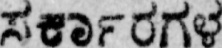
ಸರ್ಕಾರಗಳ
